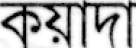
কয়াদা
